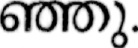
ഞ്ഞു.
